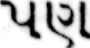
પણ
